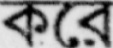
করে
